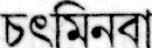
চৎমিনবা
